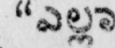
“ಎಲ್ಲಾ
